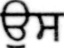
ਉਸ
